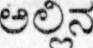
ಅಲ್ಲಿನ
